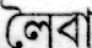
লৈবা
